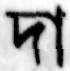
দা
